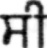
ਸੀ
